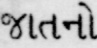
જાતનો
